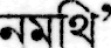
নমথি’
